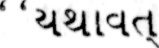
"યથાવત્
